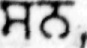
ਸਨ,
